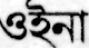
ওইনা
